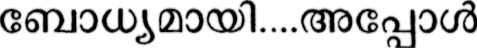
ബോധ്യമായി...അപ്പോള്‍
